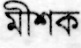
মীশক
